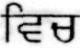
ਵਿਚ
